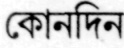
কোনদিন
